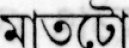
মাতটো
